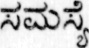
ಸಮಸ್ಯೆ
